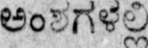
ಅಂಶಗಳಲ್ಲಿ
